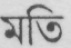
মতি
